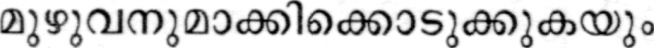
മുഴുവനുമാക്കിക്കൊടുക്കുകയും
